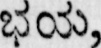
ಭಯ,
